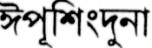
ঈপূশিংদুনা
